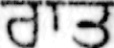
ਰਾਤ
